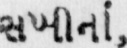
સખીનાં,
